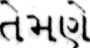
તેમણે
